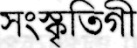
সংস্কৃতিগী
